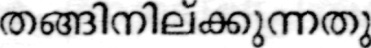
തങ്ങിനില്ക്കുന്നതു
